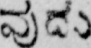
ವುದು
